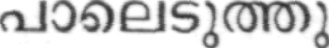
പാലെടുത്തു
